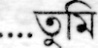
....তুমি
